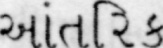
આંતરિક
